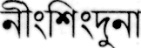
নীংশিংদুনা
